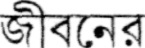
জীবনের
